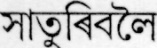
সাতুৰিবলৈ
